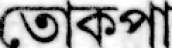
তোকপা
